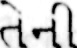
તેની
